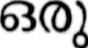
ഒരു
